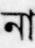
না
